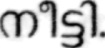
നീട്ടി.
